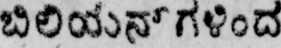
ಬಿಲಿಯನ್‌ಗಳಿಂದ
